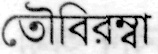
তৌবিরম্বা
